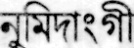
নুমিদাংগী
